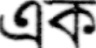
এক
